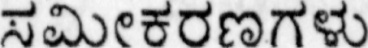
ಸಮೀಕರಣಗಳು
